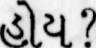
હોય?
